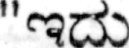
“ಇದು
